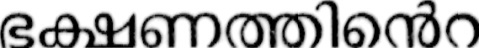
ഭക്ഷണത്തിന്റെ
